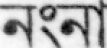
নংনা
